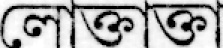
লোক্তাক্তা
